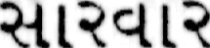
સારવાર
